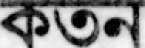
কতন
